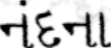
નંદના
